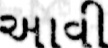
આવી
